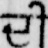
ਦੀ
